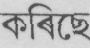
কৰিছে
